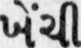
ખેંચી
